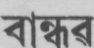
বান্ধৱ
